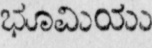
ಭೂಮಿಯು
